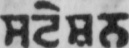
ਸਟੇਸ਼ਨ
